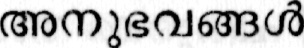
അനുഭവങ്ങള്‍
